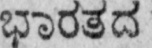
ಭಾರತದ
